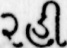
રહી
